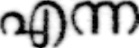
എന്ന
